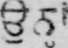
ਉਨ੍ਹਾਂ
